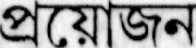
প্রয়োজন
